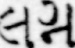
લગ્ન
